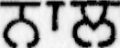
ਨਾਲ
